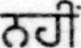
ਨਹੀਂ
